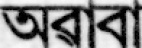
অৱাবা
